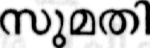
സുമതി
